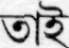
তাই
